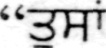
''ਤੁਸਾਂ
